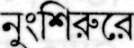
নুংশিরুরে
